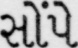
સોંપો
